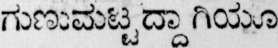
ಗುಣಮಟ್ಟದ್ದಾಗಿಯೂ
